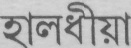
হালধীয়া
